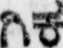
ಗಿಕ
